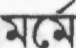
মর্মে
